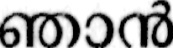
ഞാന്‍
